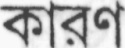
কারণ
